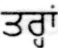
ਤਰ੍ਹਾਂ
